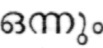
ഒന്നും
